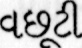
વછૂટી
